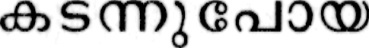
കടന്നുപോയ
